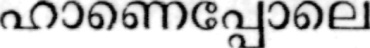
ഹാണെപ്പോലെ
